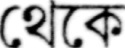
থেকে
